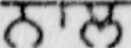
ਨਾਲ
